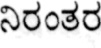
ನಿರಂತರ
